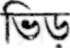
ভিড়
